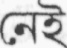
নেই
